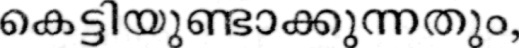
കെട്ടിയുണ്ടാക്കുന്നതും,
